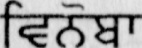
ਵਿਨੋਬਾ
